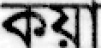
কয়া
